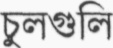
চুলগুলি
